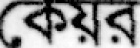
কেয়র
